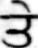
ਤੇ
